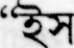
“ইস
